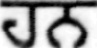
ਹਨ
